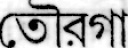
তৌরগা
